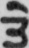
ਤੇ
